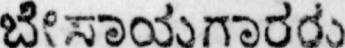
ಬೇಸಾಯಗಾರರು
